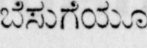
ಬೆಸುಗೆಯೂ
